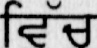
ਵਿੱਚ
